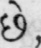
છે,
